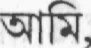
আমি,
